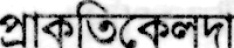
প্রাকতিকেলদা
